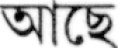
আছে
